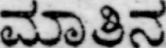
ಮಾತಿನ
